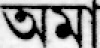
অমা
